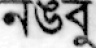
নঙবু
